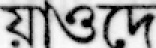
য়াওদে
